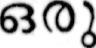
ഒരു
